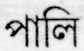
পালি
